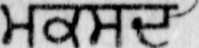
ਮਕਸਦ
